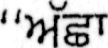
''ਅੱਛਾ
